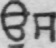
ਉਸ
